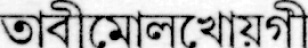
তাবীমোলখোয়গী
